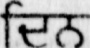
ਦਿਨ
